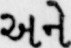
અને
